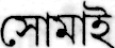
সোমাই
